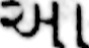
આ
